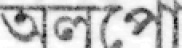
অলপো
